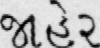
જાહેર
